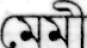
মেমী
